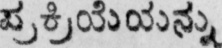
ಪ್ರಕ್ರಿಯೆಯನ್ನು
